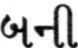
બની
